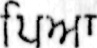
ਪਿਆ
